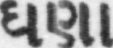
ઘણા
